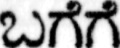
ಬಗೆಗೆ
